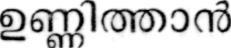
ഉണ്ണിത്താന്‍
